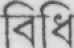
বিধি
